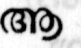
ആ
